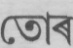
তোৰ
